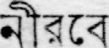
নীরবে
